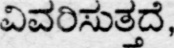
ವಿವರಿಸುತ್ತದೆ,
